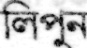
লিপুন
